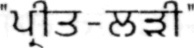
'ਪ੍ਰੀਤ-ਲੜੀ'
